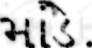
માંડે.
